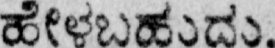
ಹೇಳಬಹುದು.
